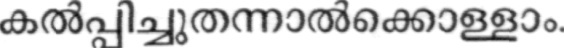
കല്‍പ്പിച്ചുതന്നാല്‍ക്കൊള്ളാം.
